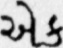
એક
